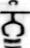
ਨੂੰ
